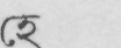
হে
